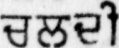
ਚਲਦੀ
